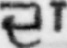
ਦਾ
